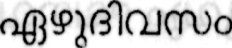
ഏഴുദിവസം
